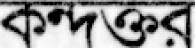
কন্দক্তর
